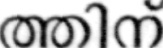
ത്തിന്
